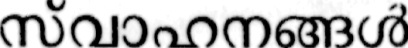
സ്വാഹനങ്ങള്‍
